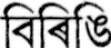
বিৰিঙি
